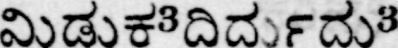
ಮಿಡುಕ3ದಿರ್ದುದು3
